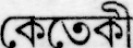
কেতেকী
